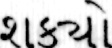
શક્યો
